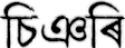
চিঞৰি
